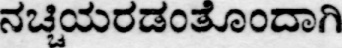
ನಚ್ಚಿಯರಡಂತೊಂದಾಗಿ
